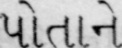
પોતાને
